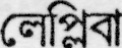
লেপ্লিবা
